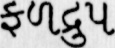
ફળદ્રુપ
